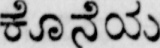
ಕೊನೆಯ
